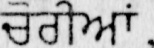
ਚੋਰੀਆਂ,
